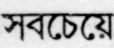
সবচেয়ে
